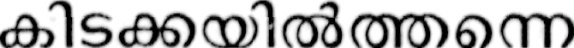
കിടക്കയില്‍ത്തന്നെ
